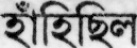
হাঁহিছিল
